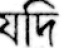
যদি
